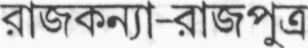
রাজকন্যা-রাজপুত্র
